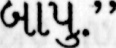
બાપુ."
